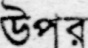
উপর
